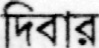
দিবার
